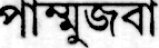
পাম্মুজবা
